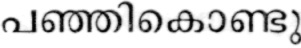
പഞ്ഞികൊണ്ടു
